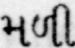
મળી
